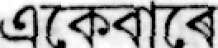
একেবাৰে
